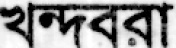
খন্দবরা
